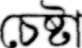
চেষ্টা
